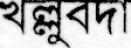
খল্লুবদা
